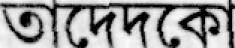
তাদেদকো
